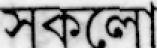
সকলো
